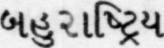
બહુરાષ્ટ્રિય
